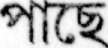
পাছে
